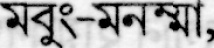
মবুং-মনম্মা,
